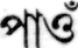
পাওঁ
